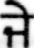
ਜੇ
